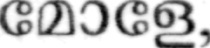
മോളേ,
